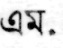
এম.
